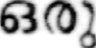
ഒരു
